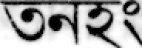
তনহং
